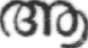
ആ
